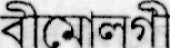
বীমোলগী
